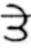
ਤੇ
